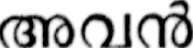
അവന്‍
